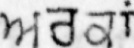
ਅਰਕਾਂ
